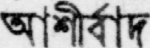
আশীর্বাদ
